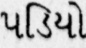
પડિયો
